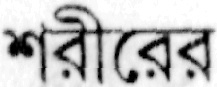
শরীরের
